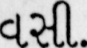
વસી.
